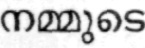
നമ്മുടെ
